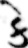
કે
